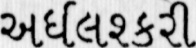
અર્ધલશ્કરી
